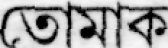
তোমাক
